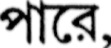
পারে,
